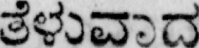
ತೆಳುವಾದ
